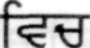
ਵਿਚ
